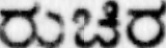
ರುಚಿರ
